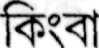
কিংবা
